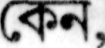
কেন,
